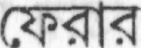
ফেরার
